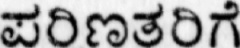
ಪರಿಣತರಿಗೆ
